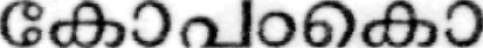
കോപംകൊ
